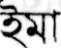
ইমা
